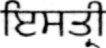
ਇਸਤ੍ਰੀ
